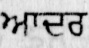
ਆਦਰ
